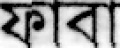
ফাবা
